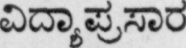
ವಿದ್ಯಾಪ್ರಸಾರ
